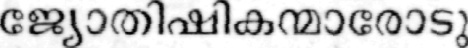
ജ്യോതിഷികന്മാരോടു
